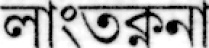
লাংতক্ননা
